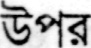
উপর
